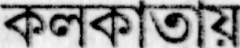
কলকাতায়
